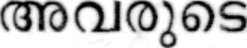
അവരുടെ
